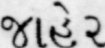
જાહેર
